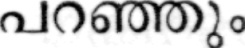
പറഞ്ഞും
